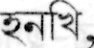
হনখি,
